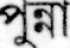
পুন্না
